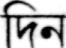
দিন
